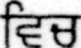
ਵਿਚ
